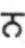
ਨ
